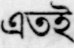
এতই
